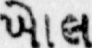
ખોલ
